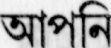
আপনি
